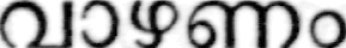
വാഴണം
